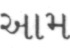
આમ
